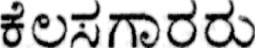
ಕೆಲಸಗಾರರು
